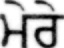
ਮੇਰੇ
